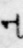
ન
